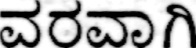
ವರವಾಗಿ
